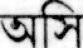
অসি
